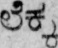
ಲೆಕ್ಕ
